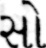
સો
